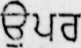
ਉਪਰ
